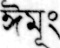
ঈমূং
